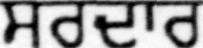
ਸਰਦਾਰ
